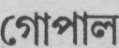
গোপাল
